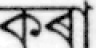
কৰা
